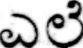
ಎಲೆ
